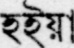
হইয়া
